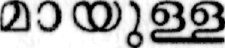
മായുള്ള
